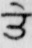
ਤੇ
